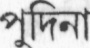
পুদিনা
